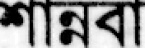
শান্নবা
